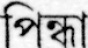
পিন্ধা
